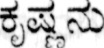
ಕೃಷ್ಣನು
